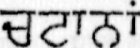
ਚਟਾਨਾਂ
